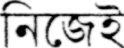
নিজেই
